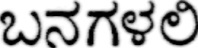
ಬನಗಳಲಿ
